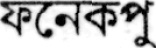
ফনেকপু
